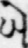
બે
